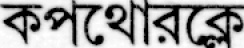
কপথোরক্লে
